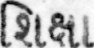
શિક્ષા
